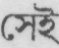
সেই
